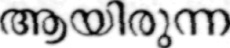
ആയിരുന്ന
